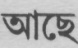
আছে
